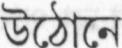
উঠোনে
